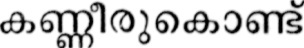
കണ്ണീരുകൊണ്ട്
